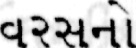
વરસનો
